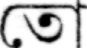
তো
